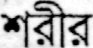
শরীর
